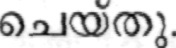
ചെയ്തു.
